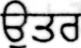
ਉਤਰ
